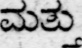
ಮತ್ತು
